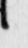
ને
